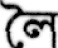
লৈ
